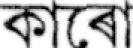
কাৰো
